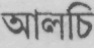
আলচি
